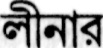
লীনার
